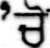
'ਚੋਂ
